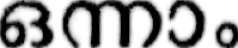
ഒന്നാം
